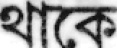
থাকে
